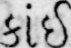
કાંઈ
